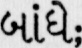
બાંધે;
